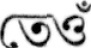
তেওঁ
